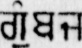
ਗੁੰਬਜ
